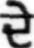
ਦੇ
